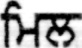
ਮਿਲ
